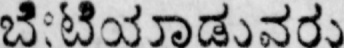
ಬೇಟೆಯಾಡುವರು
